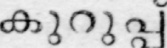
കുറുപ്പ്
